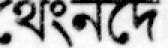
থেংনদে
